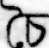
চৈ
